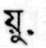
য়ু.
